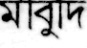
মীবুদি
